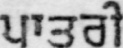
ਪਾਤਰੀ
